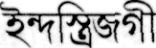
ইন্দস্ত্রিজগী
